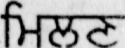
ਮਿਲਣ
